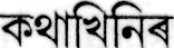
কথাখিনিৰ
